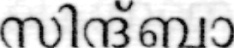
സിന്ദ്ബാ
